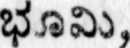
ಭೂಮಿ,
